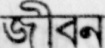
জীবন
